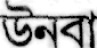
উনবা
